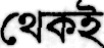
থেকই
